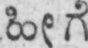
ಹೀಗೆ
